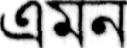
এমন
